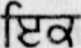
ਇਕ
